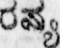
ರಷ್ಯ
